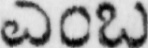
ಎಂಬ
